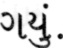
ગયું.
